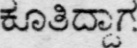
ಕೂತಿದ್ದಾಗ
